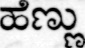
ಹೆಣ್ಣು
